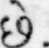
છે.
